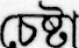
চেষ্টা
